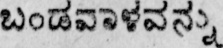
ಬಂಡವಾಳವನ್ನು
